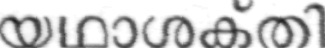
യഥാശക്തി
